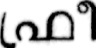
ഫ്രീ
